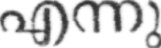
എന്നു
